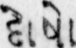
દોષો
